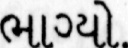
ભાગ્યો.
